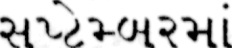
સપ્ટેમ્બરમાં
